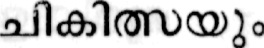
ചികിത്സയും
